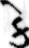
કે
